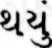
થયું
